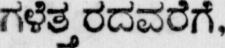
ಗಳೆತ್ತರದವರೆಗೆ,
